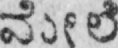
ಮೇಲೆ
